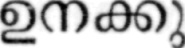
ഉനക്കു
